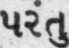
પરંતુ
